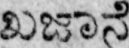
ಖಜಾನೆ
